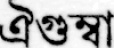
ঐগুম্বা
